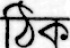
ঠিক
